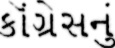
કૉગ્રેસનું
